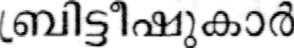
ബ്രിട്ടീഷുകാര്‍
